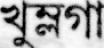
খুম্লগা
